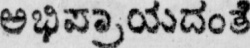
ಅಭಿಪ್ರಾಯದಂತೆ
